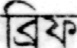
ব্রিফ
